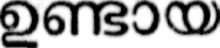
ഉണ്ടായ
